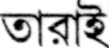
তারাই
